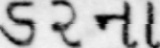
ડરના
